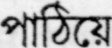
পাঠিয়ে
